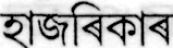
হাজৰিকাৰ
